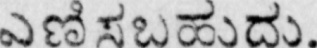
ಎಣಿಸಬಹುದು.
